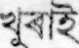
খুৰাই
